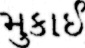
મુકાઈ
